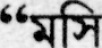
“মসি
